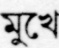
মুখে
